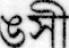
ঙসী
